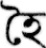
হৈ
